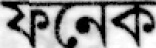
ফনেক
